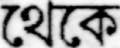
থেকে
